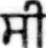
ਸੀ
